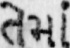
તેમાં
